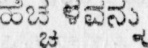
ಹೆಚ್ಚಳವನ್ನು
